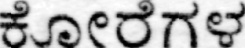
ಕೋರೆಗಳ
